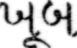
ખૂબ
